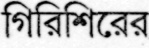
গিরিশিরের
